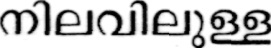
നിലവിലുള്ള
